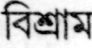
বিশ্রাম
